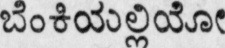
ಬೆಂಕಿಯಲ್ಲಿಯೋ
